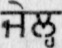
ਜੇਲ੍ਹ
